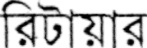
রিটায়ার
